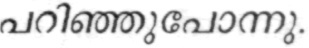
പറിഞ്ഞുപോന്നു.
